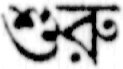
শুরু
